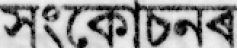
সংকোচনৰ
